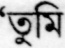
‘তুমি
